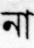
না
